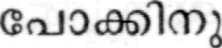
പോക്കിനു
